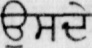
ਉਸਦੇ
